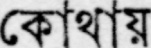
কোথায়
